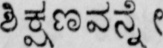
ಶಿಕ್ಷಣವನ್ನೇ
